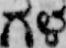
ಗಳ
